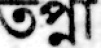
তপ্না
